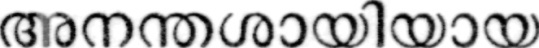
അനന്തശായിയായ
